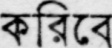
করিবে
